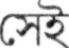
সেই
